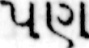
પણ
